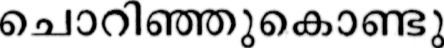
ചൊറിഞ്ഞുകൊണ്ടു
